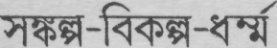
সঙ্কল্প-বিকল্প-ধৰ্ম্ম
